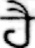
ਹੈ
